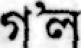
গ'ল
